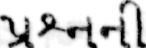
પ્રશ્નની
